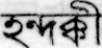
হন্দক্কী
